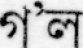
গ'ল
